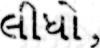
લીધો,
